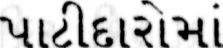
પાટીદારોમાં
